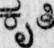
ಕೃತಿ
